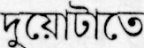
দুয়োটাতে
